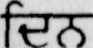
ਦਿਨ
